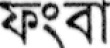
ফংবা
